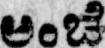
ಅಂಚೆ
